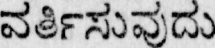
ವರ್ತಿಸುವುದು
